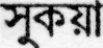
সুকয়া
